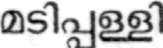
മടിപ്പള്ളി
